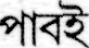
পাবই
